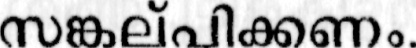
സങ്കല്പിക്കണം.
